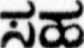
ಸಹ
